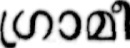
ഗ്രാമീ
